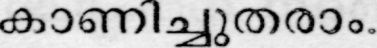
കാണിച്ചുതരാം.
